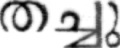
തച്ചു
